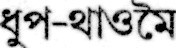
ধুপ-থাওমৈ
